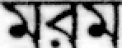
মরম
